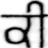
ਕੀ
